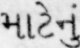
માટેનું
